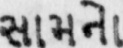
સામનો
